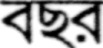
বছর
